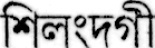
শিলংদগী
